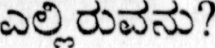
ಎಲ್ಲಿರುವನು?
